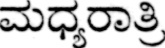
ಮಧ್ಯರಾತ್ರಿ
